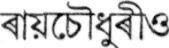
ৰায়চৌধুৰীও
